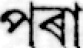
পৰা
